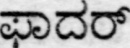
ಫಾದರ್
